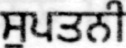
ਸੁਪਤਨੀ
